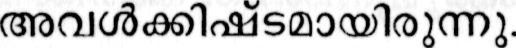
അവള്‍ക്കിഷ്ടമായിരുന്നു.
